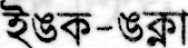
ইঙক-ঙক্না
